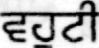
ਵਹੁਟੀ
